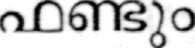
ഫണ്ടും
